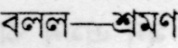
বলল–শ্রমণ
